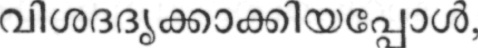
വിശദദൃക്കാക്കിയപ്പോള്‍,
